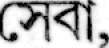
সেবা,
